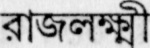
রাজলক্ষ্মী
